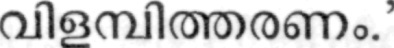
വിളമ്പിത്തരണം.'
